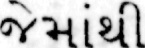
જેમાંથી
